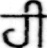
ਹੀ
